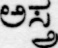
ಅಸ್ತ್ರ
